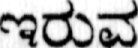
ಇರುವ
